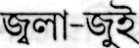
জ্বলা-জুই
